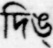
দিঙ্
